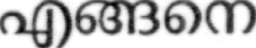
എങ്ങനെ
